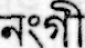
নংগী
